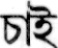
চাই
